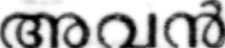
അവന്‍
